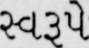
સ્વરૂપે
